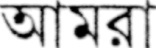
আমরা
